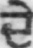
ਦੇ
